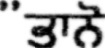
''ਭਾਨੋ
